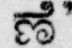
ಣೆ’
